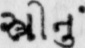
સ્ત્રીનું
